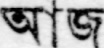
আজ
